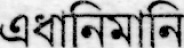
এধানিমানি
